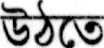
উঠতে
